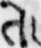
તો
